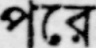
পরে
